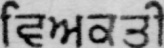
ਵਿਅਕਤੀ
